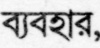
ব্যবহার,
